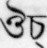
ঔচ্
